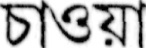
চাওয়া
